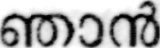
ഞാന്‍
